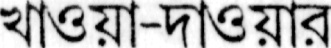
খাওয়া-দাওয়ার
